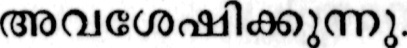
അവശേഷിക്കുന്നു.
